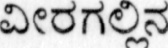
ವೀರಗಲ್ಲಿನ
